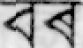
বৰ
